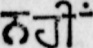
ਨਹੀਂ
